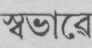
স্বভাৱে
